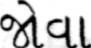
જોવા
